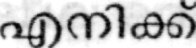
എനിക്ക്
